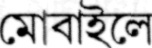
মোবাইলে
